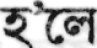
হ'লে
